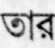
তার
